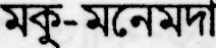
মকু-মনেমদা
